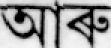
আৰু
